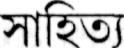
সাহিত্য
